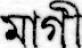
মাগী
